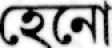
হেনো
